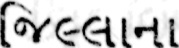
જિલ્લાના
